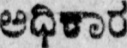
ಅಧಿಕಾರ
